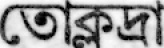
তোক্লদ্রা
